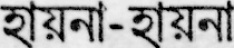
হায়না-হায়না
